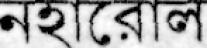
নহারোল
